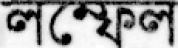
লম্ফেল
